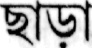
ছাড়া
